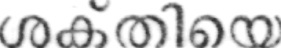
ശക്തിയെ
